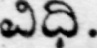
ವಿಧಿ.
